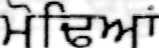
ਮੋਢਿਆਂ
